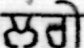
ਲਗੇ
